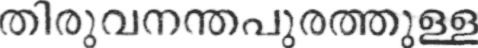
തിരുവനന്തപുരത്തുള്ള
